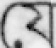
যে
